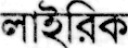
লাইরিক
